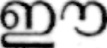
ഈ
